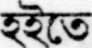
হইতে
